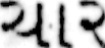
ચાર
